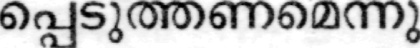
പ്പെടുത്തണമെന്നു
